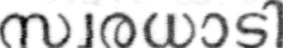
സ്വരധാടി
